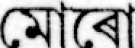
মোৰো
